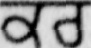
ਕਰ
